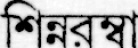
শিন্নরম্বা
